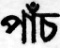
পাঁচ
